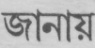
জানায়
